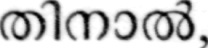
തിനാല്‍,
